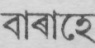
বাৰাহে
